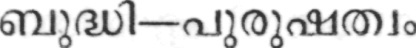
ബുദ്ധി-പുരുഷത്വം
